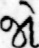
જો
